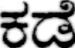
ಕಡೆ
